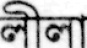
লীলা
